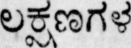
ಲಕ್ಷಣಗಳ
